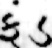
ફંડ
